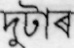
দুটাৰ
